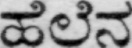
ಹೆಲೆನ
